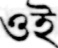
ওই
